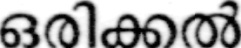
ഒരിക്കല്‍
